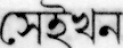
সেইখন
